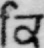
ਕਿ
